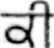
ਕੀ
